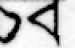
চব
